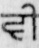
ਵੀ
